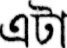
এটা
